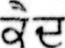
ਕੈਦ
